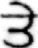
ਤੇ
